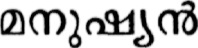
മനുഷ്യന്‍
